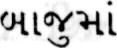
બાજુમાં
